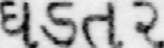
ઘડતર
